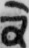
ਕੇ
